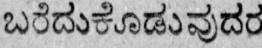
ಬರೆದುಕೊಡುವುದರ
